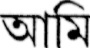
আমি
